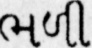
ભળી
